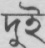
দুই
